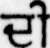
ਦੀ
